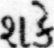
શકે
